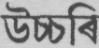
উচ্চৰি
